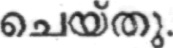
ചെയ്തു.
